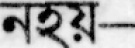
নহয়-
